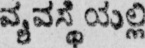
ವ್ಯವಸ್ಥೆಯಲ್ಲಿ
